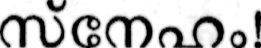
സ്നേഹം!
